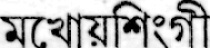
মখোয়শিংগী
